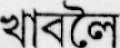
খাবলৈ
